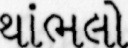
થાંભલો
